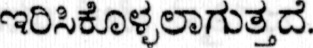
ಇರಿಸಿಕೊಳ್ಳಲಾಗುತ್ತದೆ.
